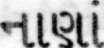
નાણાં
